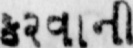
કરવાની
